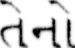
તેનો
